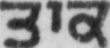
ਤਾਕ
